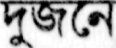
দুজনে
